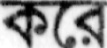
করে
